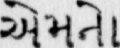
એમનો
